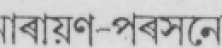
নাৰায়ণ-পৰসনে
